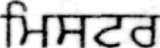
ਮਿਸਟਰ
